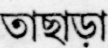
তাছাড়া
